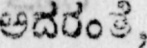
ಅದರಂತೆ,
